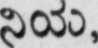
ನಿಯ,
